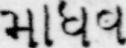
માધવ
